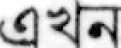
এখন
